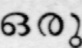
ഒരു
